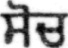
ਸੋਚ
